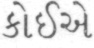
કોઈએ
